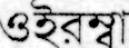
ওইরম্বা
